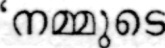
‘നമ്മുടെ
